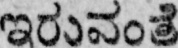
ಇರುವಂತೆ
